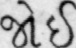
જોઈ
